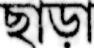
ছাড়া
